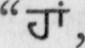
''ਹਾਂ,
